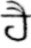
ਹੈ
